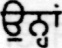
ਉਨ੍ਹਾਂ
